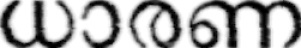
ധാരണ
